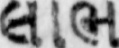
લાભ
